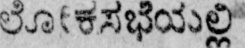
ಲೋಕಸಭೆಯಲ್ಲಿ
